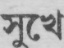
সুখে
